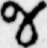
જ
